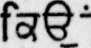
ਕਿਉਂ
